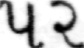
પર
